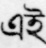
এই
